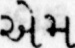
એમ
